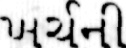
ખર્ચની
